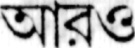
আরও
